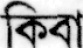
কিবা
